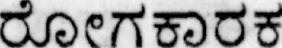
ರೋಗಕಾರಕ
